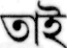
তাই
